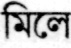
মিলে
